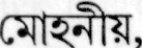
মোহনীয়,
